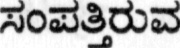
ಸಂಪತ್ತಿರುವ
